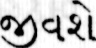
જીવશે
